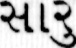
સારુ
